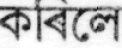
কৰিলে
